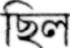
ছিল
